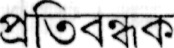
প্রতিবন্ধক
